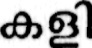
കളി
